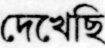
দেখেছি
